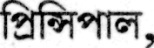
প্রিন্সিপাল,
